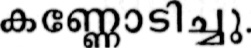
കണ്ണോടിച്ചു.
